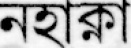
নহাক্না
